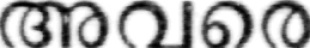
അവരെ
